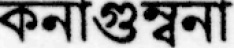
কনাগুন্বনা
